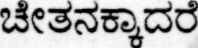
ಚೇತನಕ್ಕಾದರೆ
